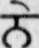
ਨੇ
